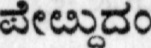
ಪೇೞ್ದುದಂ
